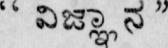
“ವಿಜ್ಞಾನ”
